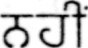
ਨਹੀਂ
